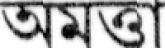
অমত্তা
